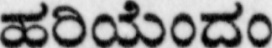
ಹರಿಯೆಂದಂ
